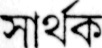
সার্থক
